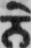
ਨੇ
